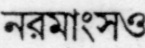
নরমাংসও
